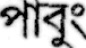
পাবুং
